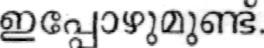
ഇപ്പോഴുമുണ്ട്.
